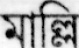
মাল্লি
